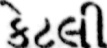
કેટલી
